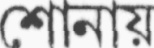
শোনায়
